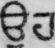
ਉਹ
